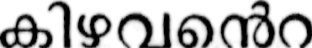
കിഴവന്റെ
